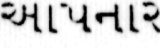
આપનાર
